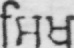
ਸਿਖ
